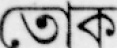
তোক
